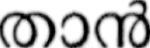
താന്‍
